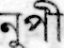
নুপী
